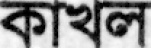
কাখল
